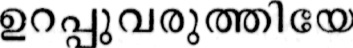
ഉറപ്പുവരുത്തിയേ
